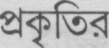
প্রকৃতির
